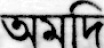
অমদি
